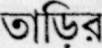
তাড়ির
